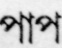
পাপ
